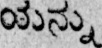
ಯನ್ನು
